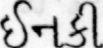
ઈનકી
